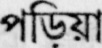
পড়িয়া
